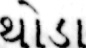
થોડા
